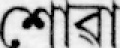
শোৱা
